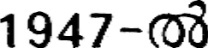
1947-ല്‍
